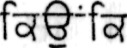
ਕਿਉਂਕਿ
